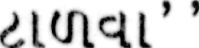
ટાળવા"
